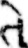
તે
